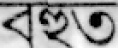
বহুত
